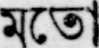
মতো
